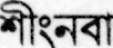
শীংনবা
